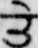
ਤੇ
